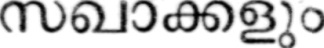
സഖാക്കളും
